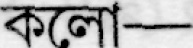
কলো-
